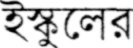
ইস্কুলের
